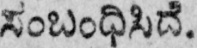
ಸಂಬಂಧಿಸಿದೆ.
